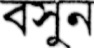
বসুন
